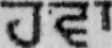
ਹਵਾ
